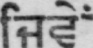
ਜਿਵੇਂ
